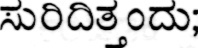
ಸುರಿದಿತ್ತಂದು;
